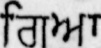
ਗਿਆ
